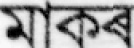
মাকৰ
